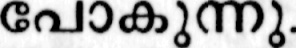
പോകുന്നു.
